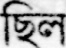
ছিল
